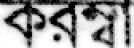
করম্বা
